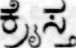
ಕ್ರೈಸ್ತ
